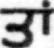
ਤਾਂ
